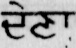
ਦੇਣਾ
